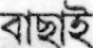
বাছাই
